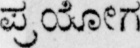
ಪ್ರಯೋಗ
